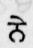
ਨੇ
